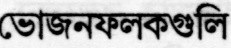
ভোজনফলকগুলি
